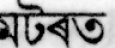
মটৰত
